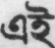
এই
